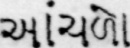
આંચળો
